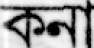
কনা
